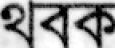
থবক
